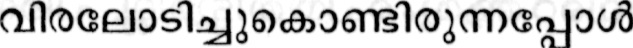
വിരലോടിച്ചുകൊണ്ടിരുന്നപ്പോള്‍
